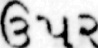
ઉપર
